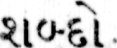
શબ્દો
